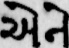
એને
